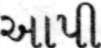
આપી
